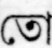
তো
